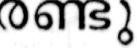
രണ്ടു
